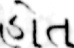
હોત
